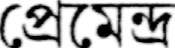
প্রেমেন্দ্র
